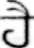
ਹੈ
